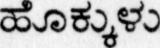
ಹೊಕ್ಕುಳು
